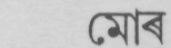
মোৰ
